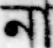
না
